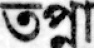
তপ্না
